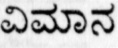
ವಿಮಾನ
